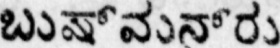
ಬುಷ್‌ಮನ್‌ರು
